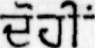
ਦੋਹੀਂ
